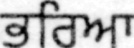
ਭਰਿਆ
